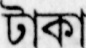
টাকা
